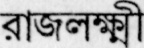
রাজলক্ষ্মী
